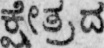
ಕ್ಷೇತ್ರದ
